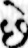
છે
